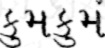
કુમકુમં
